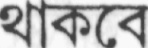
থাকবে
